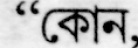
"কোন,
